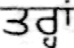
ਤਰ੍ਹਾਂ
